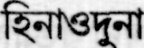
হিনাওদুনা
